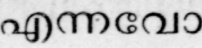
എന്നവോ
